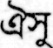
ঐসু
